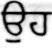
ਉਹ
